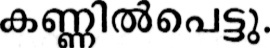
കണ്ണില്‍പെട്ടു.
